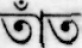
তাঁত
